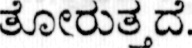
ತೋರುತ್ತದೆ.
